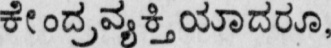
ಕೇಂದ್ರವ್ಯಕ್ತಿಯಾದರೂ,
